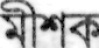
মীশক
